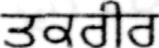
ਤਕਰੀਰ
